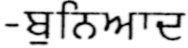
-ਬੁਨਿਆਦ
